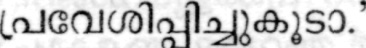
പ്രവേശിപ്പിച്ചുകൂടാ.’
